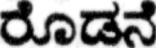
ರೊಡನೆ
